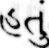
હતું
